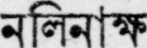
নলিনাক্ষ
